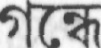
গন্ধে
